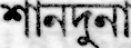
শানদুনা
